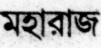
মহারাজ
